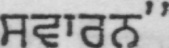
ਸਵਾਰਨ''
